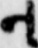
ન
